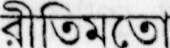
রীতিমতো
